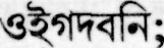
ওইগদবনি;
